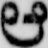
ಆ
